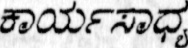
ಕಾರ್ಯಸಾಧ್ಯ
